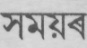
সময়ৰ
